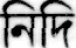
নিদি
